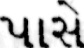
પાસે
